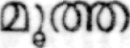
മൂത്ത
